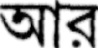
আর
